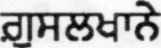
ਗ਼ੁਸਲਖਾਨੇ
